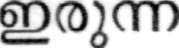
ഇരുന്ന
